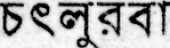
চৎলুরবা
